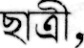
ছাত্রী,
